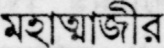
মহাত্মাজীর
